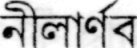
নীলার্ণব
